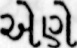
એણે
